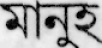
মানুহ
